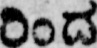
ರಿಂದ
